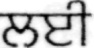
ਲਈ
